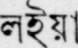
লইয়া
